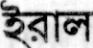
ইরাল
